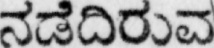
ನಡೆದಿರುವ
